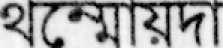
থম্মোয়দা
